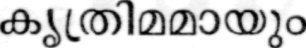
കൃത്രിമമായും
